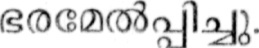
ഭരമേല്‍പ്പിച്ചു.
